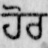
ਹੋਰ
